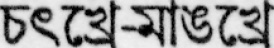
চৎখ্রে-মাঙখ্রে
